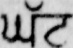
ਘੱਟ
